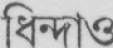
ধিন্দাও
